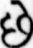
છે
